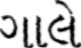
ગાલે
